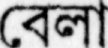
বেলা
